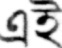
এই
